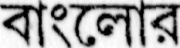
বাংলোর
